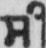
ਸੀ
